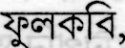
ফুলকবি,
